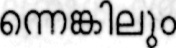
ന്നെങ്കിലും
